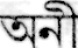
অনী
